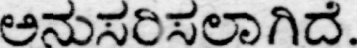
ಅನುಸರಿಸಲಾಗಿದೆ.
